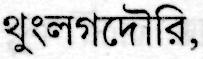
থুংলগদৌরি,
